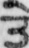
ਤੇ
